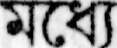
মধ্যে
